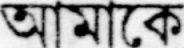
আমাকে
